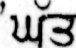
'ਘੱਤ
